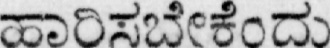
ಹಾರಿಸಬೇಕೆಂದು
